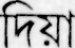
দিয়া
